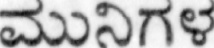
ಮುನಿಗಳ
